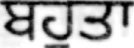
ਬਹੁਤਾ
